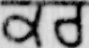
ਕਰ
